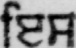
ਇਸ
